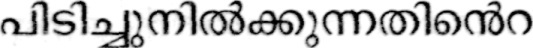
പിടിച്ചുനില്‍ക്കുന്നതിന്റെ
